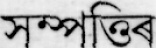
সম্পত্তিৰ
